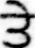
ਤੇ
